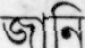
জানি
